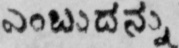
ಎಂಬುದನ್ನು
